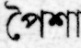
পৈশা
